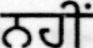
ਨਹੀਂ
